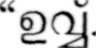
“ഉവ്വ്.
